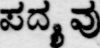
ಪದ್ಯವು
